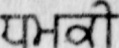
ਧਮਕੀ
